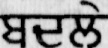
ਬਦਲੇ
